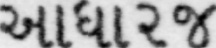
આધારજ
